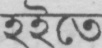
হইতে
